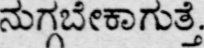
ನುಗ್ಗಬೇಕಾಗುತ್ತೆ.
